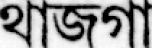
থাজগা
